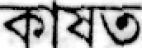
কাষত
